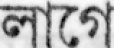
লাগে
